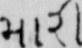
મારી
